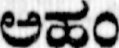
ಅಹಂ
